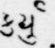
કર્યુ.
